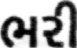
ભરી
